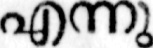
എന്നു
